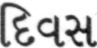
દિવસ
